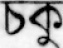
চকু
